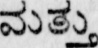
ಮತ್ತು
